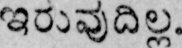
ಇರುವುದಿಲ್ಲ.
